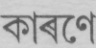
কাৰণে
